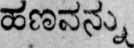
ಹಣವನ್ನು
